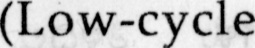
(Low-cycle
